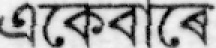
একেবাৰে
